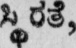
ಸ್ಥಿರತೆ,
